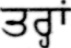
ਤਰ੍ਹਾਂ
